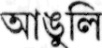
আঙুলি
